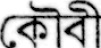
কৌবী
